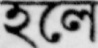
হলে
